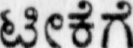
ಟೀಕೆಗೆ
